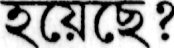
হয়েছে?
